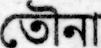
তৌনা
